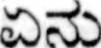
ಏನು
